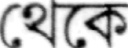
থেকে
